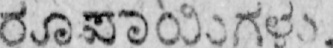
ರೂಪಾಯಿಗಳು.
